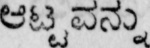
ಅಟ್ಟವನ್ನು
